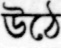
উঠে
